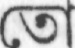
তো
